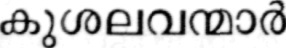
കുശലവന്മാര്‍
